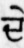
ਦੇ
